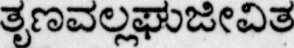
ತೃಣವಲ್ಲಘುಜೀವಿತ
